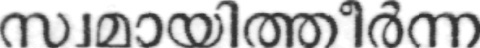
സ്വമായിത്തീര്‍ന്ന
